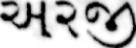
અરજી
